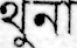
থুনা
